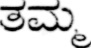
ತಮ್ಮ
